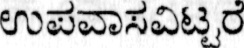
ಉಪವಾಸವಿಟ್ಟರೆ
